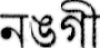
নঙগী
